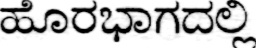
ಹೊರಭಾಗದಲ್ಲಿ
